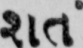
શત
